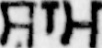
ਸ਼ਾਮ
